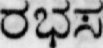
ರಭಸ
